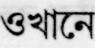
ওখানে
